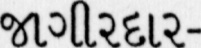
જાગીરદાર-
